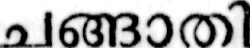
ചങ്ങാതി
